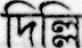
দিল্লি
